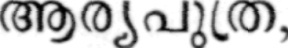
ആര്യപുത്ര,
